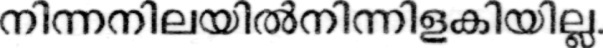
നിന്നനിലയില്‍നിന്നിളകിയില്ല.
